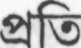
প্রতি
